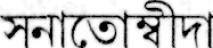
সনাতোম্বীদা
